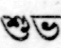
শুভ
